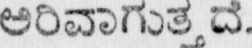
ಅರಿವಾಗುತ್ತದೆ.
